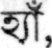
হ্যাঁ,
